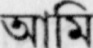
আমি
